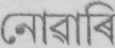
নোৱাৰি
